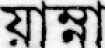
য়াম্না
